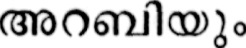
അറബിയും
